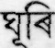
ঘূৰি
